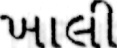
ખાલી
